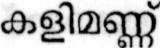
കളിമണ്ണ്
